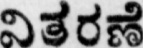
ವಿತರಣೆ
